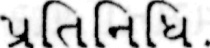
પ્રતિનિધિ.
